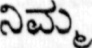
ನಿಮ್ಮ
